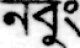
নবুং
